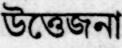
উত্তেজনা
